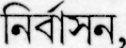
নির্বাসন,
